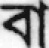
বা
